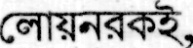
লোয়নরকই,
